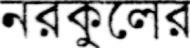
নরকুলের
